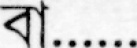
বা......
